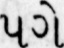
પગે
